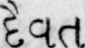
દૈવત
